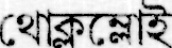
থোক্লম্লোই
